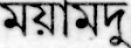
ময়ামদু
